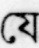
যে
